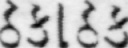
ઠકાઠક
